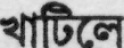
খাটিলে
